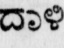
ದಾಳಿ
